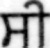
ਸੀ
